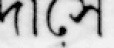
দাসে
